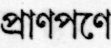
প্রাণপণে
